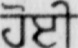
ਹੋਈ
